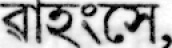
ৱাহংসে,
